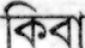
কিবা
